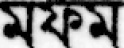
মফম
